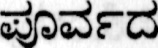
ಪೂರ್ವದ
